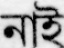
নাই
